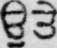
ਉਤੇ
